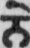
ਨੇ
